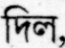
দিল,
